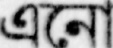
এনো
